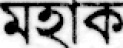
মহাক
